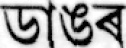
ডাঙৰ
